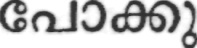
പോക്കു
